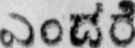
ಎಂದರೆ
